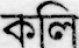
কলি
